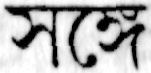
সঙ্গে
